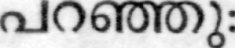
പറഞ്ഞു:
